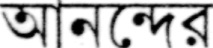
আনন্দের
